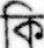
কি
